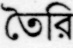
তৈরি
